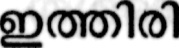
ഇത്തിരി
